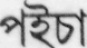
পইচা
